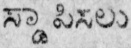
ಸ್ಥಾಪಿಸಲು
